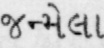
જન્મેલા
